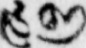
હજી
